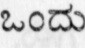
ಒಂದು
